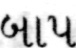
બાપ
